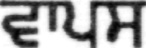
ਵਾਪਸ
